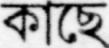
কাছে
